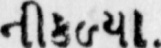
નીકળ્યો.
